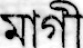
মাগী
